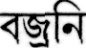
বজ্রনি
